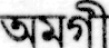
অমগী
